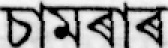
চামৰাৰ
